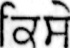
ਕਿਸੇ
